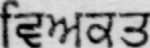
ਵਿਅਕਤ
